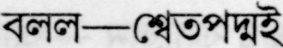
বলল–শ্বেতপদ্মই
